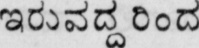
ಇರುವದ್ದರಿಂದ
